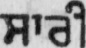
ਸਾਰੀ
